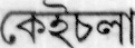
কেইচলা
